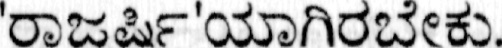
‘ರಾಜರ್ಷಿ’ಯಾಗಿರಬೇಕು.
